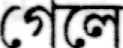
গেলে
